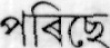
পৰিছে
